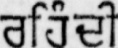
ਰਹਿੰਦੀ
